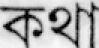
কথা
